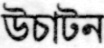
উচাটন
